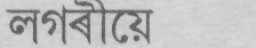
লগৰীয়ে
